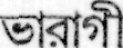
ভারাগী
